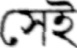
সেই
